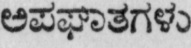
ಅಪಘಾತಗಳು
